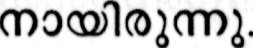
നായിരുന്നു.
